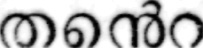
തന്റെ
